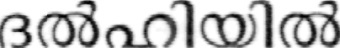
ദല്‍ഹിയില്‍
